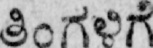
ತಿಂಗಳಿಗೆ
